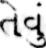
તેવું
